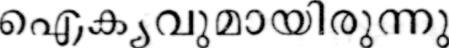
ഐക്യവുമായിരുന്നു
